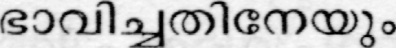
ഭാവിച്ചതിനേയും
